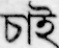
চাই
